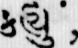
કહ્યું,'
